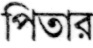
পিতার
